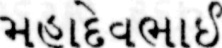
મહાદેવભાઈ
